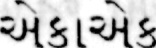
એકાએક
